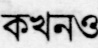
কখনও
